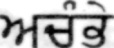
ਅਚੰਭੇ
